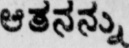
ಆತನನ್ನು
